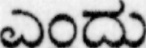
ಎಂದು
